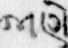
જાણે
